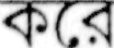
করে
